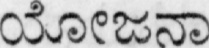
ಯೋಜನಾ
